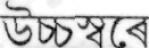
উচ্চস্বৰে
